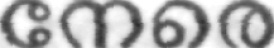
നേരെ
